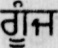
ਗੂੰਜ
